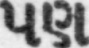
પણ
